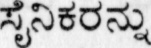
ಸೈನಿಕರನ್ನು
